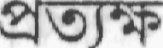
প্রত্যক্ষ
